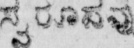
ಸ್ವರೂಪವು
